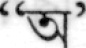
"অ'
